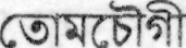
তোমচৌগী
